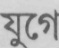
যুগে
